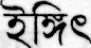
ইঙ্গিৎ
